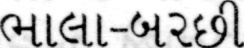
ભાલા-બરછી
